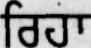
ਰਿਹਾ
